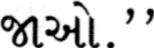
જાઓ."
